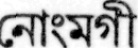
নোংমগী
